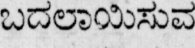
ಬದಲಾಯಿಸುವ
